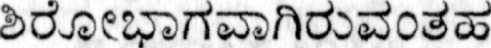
ಶಿರೋಭಾಗವಾಗಿರುವಂತಹ
